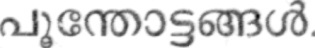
പൂന്തോട്ടങ്ങള്‍.
